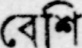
বেশি
